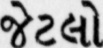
જેટલો
